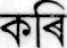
কৰি
